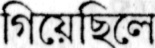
গিয়েছিলে
